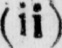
(ii)
